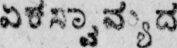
ಏಕಸ್ವಾಮ್ಯದ
